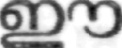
ഈ
